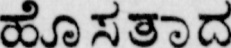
ಹೊಸತಾದ
